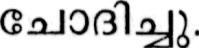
ചോദിച്ചു.
